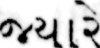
જયારે
